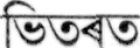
ভিতৰত
